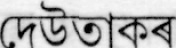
দেউতাকৰ
